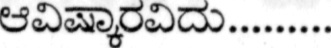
ಆವಿಷ್ಕಾರವಿದು..........
